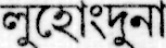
লুহোংদুনা
